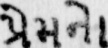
પ્રેમનો
